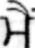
ਮੈਂ
